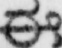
ಈ
